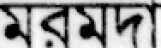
মরমদা
